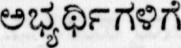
ಅಭ್ಯರ್ಥಿಗಳಿಗೆ
